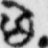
છે.
